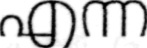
എന്ന
